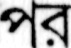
পর
